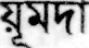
য়ুমদা
